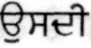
ਉਸਦੀ
